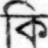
কি
